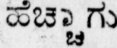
ಹೆಚ್ಚಾಗು
